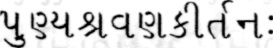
પુણ્યશ્રવણકીર્તનઃ
